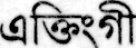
এক্তিংগী
